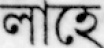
লাহে
